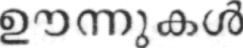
ഊന്നുകള്‍
